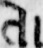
તો
